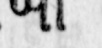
ખા
